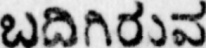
ಬದಿಗಿರುವ
